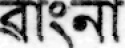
ৱাংনা
